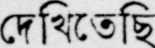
দেখিতেছি
